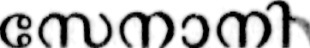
സേനാനി
